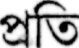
প্রতি
